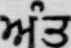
ਅੰਤ
